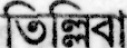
তিল্লিবা
